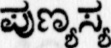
ಪುಣ್ಯಸ್ಯ
